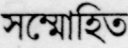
সম্মোহিত
